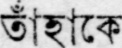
তাঁহাকে
